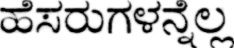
ಹೆಸರುಗಳನ್ನೆಲ್ಲ
